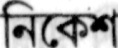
নিকেশ
